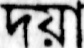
দয়া
